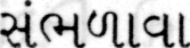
સંભળાવા
